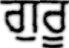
ਗੁਰੂ
